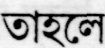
তাহলে
